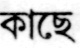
কাছে
